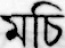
মচি
